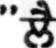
''ਲੈ
